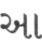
આ
